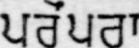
ਪਰੰਪਰਾ
